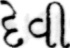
દેવી
